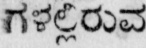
ಗಳಲ್ಲಿರುವ
